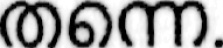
തന്നെ.
